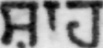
ਸ਼ਾਹ
